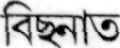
বিছনাত
